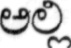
ಅಲ್ಲಿ
